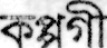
কপ্পগী
